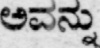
ಅವನ್ನು
